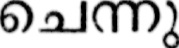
ചെന്നു
